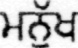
ਮਨੁੱਖ
